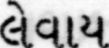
લેવાય
